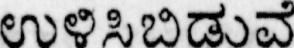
ಉಳಿಸಿಬಿಡುವೆ
